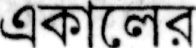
একালের
